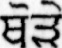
ਥੋੜੇ
